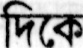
দিকে
